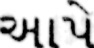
આપે
